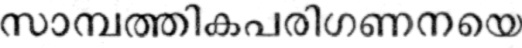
സാമ്പത്തികപരിഗണനയെ
